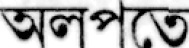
অলপতে
